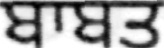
ਬਾਬਤ
